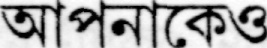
আপনাকেও
